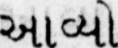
આવ્યો
